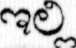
ಇಲ್ಲಿ
